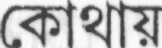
কোথায়
